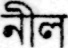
নীল
